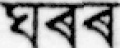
ঘৰৰ
